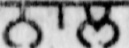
ਨਾਲ
